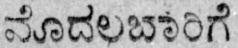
ಮೊದಲಬಾರಿಗೆ
